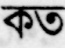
কত
